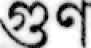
গুণ
